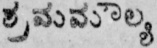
ಶ್ರಮಮೌಲ್ಯ
